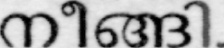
നീങ്ങി.
